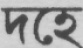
দহে
